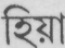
হিয়া
